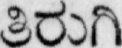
ತಿರುಗಿ
